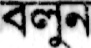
বলুন
